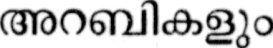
അറബികളും
